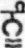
ਨੂੰ
